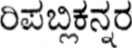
ರಿಪಬ್ಲಿಕನ್ನರ
